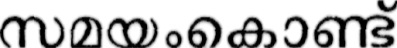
സമയംകൊണ്ട്
